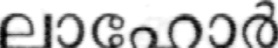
ലാഹോര്‍
